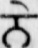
ਨੇ
